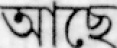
আছে
